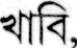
খাবি,
